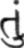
તું
